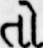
તો
